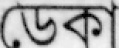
ডেকা
